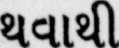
થવાથી
